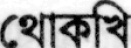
থোকখি
